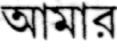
আমার
